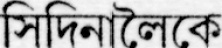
সিদিনালৈকে
